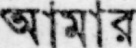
আমার
